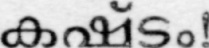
കഷ്ടം!
